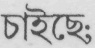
চাইছে;
